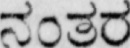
ನಂತರ
